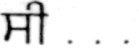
ਸੀ........
